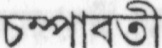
চম্পাবতী
